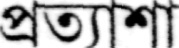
প্রত্যাশা
